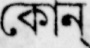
কোন্
